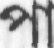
পা
